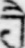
ਹੈ
